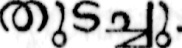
തുടച്ചു.
